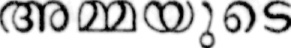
അമ്മയുടെ
